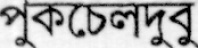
পুকচেলদুবু
